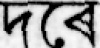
দৰে
